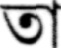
তা
